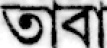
তাবা
